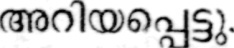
അറിയപ്പെട്ടു.
